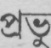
প্ৰভু
